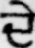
ਦੇ
